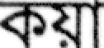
কয়া
